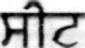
ਸੀਟ
